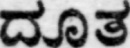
ದೂತ
